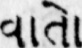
વાતો
